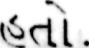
હતો.
